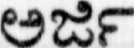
ಅರ್ಜಿ
